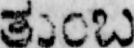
ತುಂಬ
